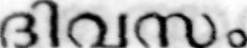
ദിവസം
